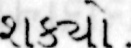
શક્યો.
